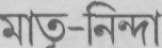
মাতৃ-নিন্দা
